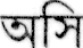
অসি
